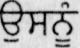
ਉਸਨੂੰ
